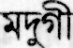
মদুগী
